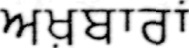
ਅਖ਼ਬਾਰਾਂ
